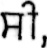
ਸੀ,
